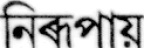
নিৰূপায়
